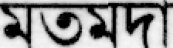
মতমদা
